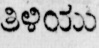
ತಿಳಿಯು
